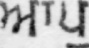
ਆਪੁ
